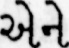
એને
